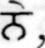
ਨੇ,
